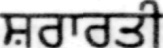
ਸ਼ਰਾਰਤੀ
